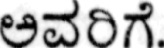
ಅವರಿಗೆ.
